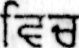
ਵਿਚ
